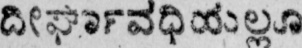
ದೀರ್ಘಾವಧಿಯಲ್ಲೂ
